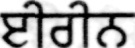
ਈਰੀਨ
